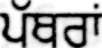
ਪੱਥਰਾਂ
